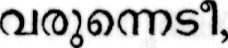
വരുന്നെടീ,
